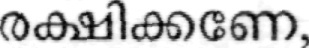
രക്ഷിക്കണേ,
